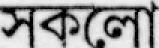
সকলো
